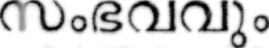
സംഭവവും
